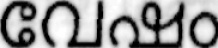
വേഷം
